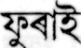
ফুৰাই
